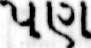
પણ
